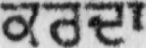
ਕਰਦਾ
